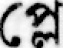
প্লে
